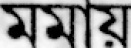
মমায়
